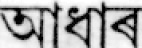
আধাৰ
